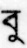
বু
